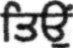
ਤਿਉਂ
